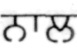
ਨਾਲ
